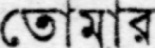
তোমার
